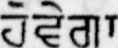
ਹੋਵੇਗਾ
